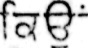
ਕਿਉਂ
